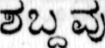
ಶಬ್ದವು
